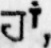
ਹਾਂ,
